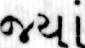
જ્યાં
